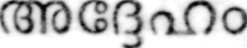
അദ്ദേഹം
